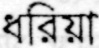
ধরিয়া
